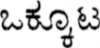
ಒಕ್ಕೂಟ
